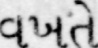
વખતે
